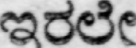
ಇರಲೇ
